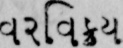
વરવિક્રય
